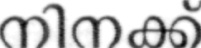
നിനക്ക്
